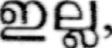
ഇല്ല,
